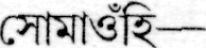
সোমাওঁহি-
